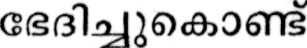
ഭേദിച്ചുകൊണ്ട്
